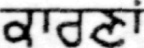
ਕਾਰਣਾਂ
